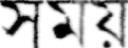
সময়
